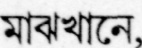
মাঝখানে,
